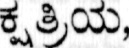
ಕ್ಷತ್ರಿಯ,
